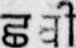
ਛਬੀ
